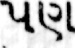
પણ
